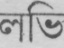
লভি
